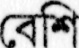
বেশি
